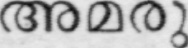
അമരു
